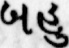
બહુ
